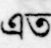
এত
